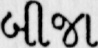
બીજા
